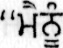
''ਮੈਨੂੰ
